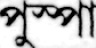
পুস্পা
